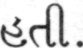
હતી.
